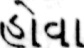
હોવા
